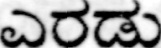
ಎರಡು
